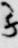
કે
